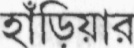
হাঁড়িয়ার
